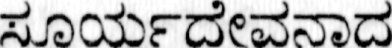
ಸೂರ್ಯದೇವನಾದ
